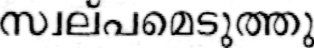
സ്വല്പമെടുത്തു
